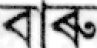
বাৰু
